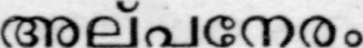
അല്പനേരം
